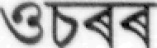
ওচৰৰ
